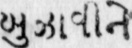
બુઝાવીને
